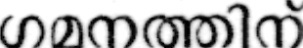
ഗമനത്തിന്
